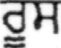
ਰੂਸ
